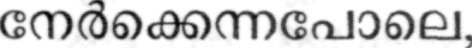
നേര്‍ക്കെന്നപോലെ,
